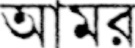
আমর
